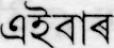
এইবাৰ
